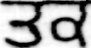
ਤਕ
